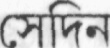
সেদিন
